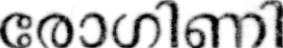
രോഗിണി
